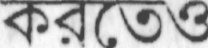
করতেও
